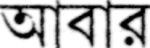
আবার
